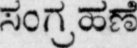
ಸಂಗ್ರಹಣೆ
